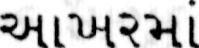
આખરમાં
